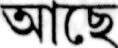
আছে
